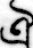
ঐ
